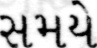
સમયે
